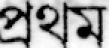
প্রথম
